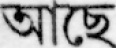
আছে
